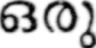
ഒരു
